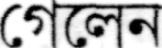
গেলেন
